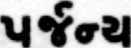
પર્જન્ય
